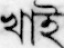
খাই
